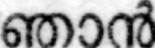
ഞാന്‍
